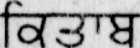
ਕਿਤਾਬ
